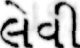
લેવી
